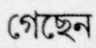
গেছেন
